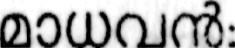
മാധവന്‍:
